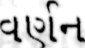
વર્ણન
